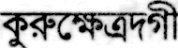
কুরুক্ষেত্রদগী
